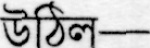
উঠিল-
